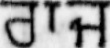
ਰਾਜ
